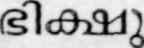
ഭിക്ഷു
